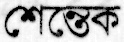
শেন্তেক
